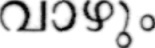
വാഴും
